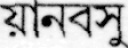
য়ানবসু
